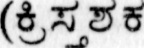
(ಕ್ರಿಸ್ತಶಕ
